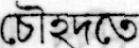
চৌহদতে
